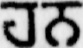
ਹਨ
